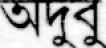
অদুবু
